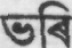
ভৰি
